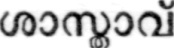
ശാസ്താവ്
